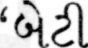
'બેટી
